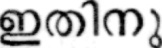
ഇതിനു
